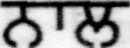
ਨਾਲ
